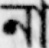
না
